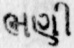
ભણી
